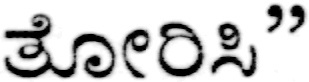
ತೋರಿಸಿ"
